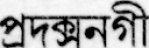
প্রদক্সনগী
